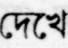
দেখে
